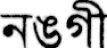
নঙগী
